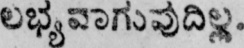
ಲಭ್ಯವಾಗುವುದಿಲ್ಲ.
